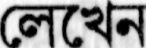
লেখেন
